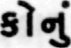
કોનું
